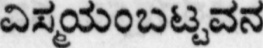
ವಿಸ್ಮಯಂಬಟ್ಟವನ
